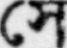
সে
